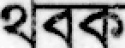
থবক
